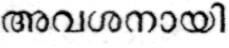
അവശനായി
